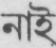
নাই
